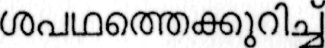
ശപഥത്തെക്കുറിച്ച്
